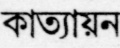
কাত্যায়ন
